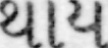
થાય
